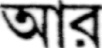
আর
